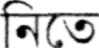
নিতে
